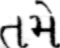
તમે
